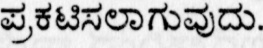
ಪ್ರಕಟಿಸಲಾಗುವುದು.
